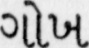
ગોખ
